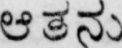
ಆತನು
